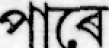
পাৰে
